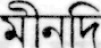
মীনদি
